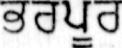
ਭਰਪੂਰ
